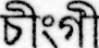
চীংগী
